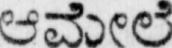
ಆಮೇಲೆ
